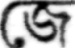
জে
